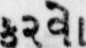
કરવો
